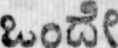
ಒಂದೇ
